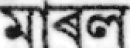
মাৰল
